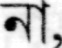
না,
